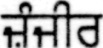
ਜ਼ੰਜੀਰ
